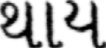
થાય
